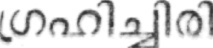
ഗ്രഹിച്ചിരി
